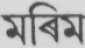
মৰিম
